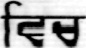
ਵਿਚ
